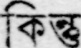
কিন্তু
